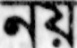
নয়
